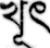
খুৎ
